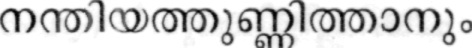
നന്തിയത്തുണ്ണിത്താനും
